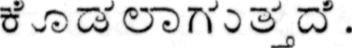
ಕೊಡಲಾಗುತ್ತದೆ.
